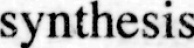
synthesis
